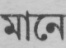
মানে
